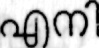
എനി
